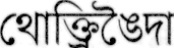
থোক্ত্রিঙৈদা
